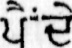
ਪੈਂਦੇ
